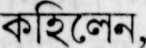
কহিলেন,
